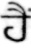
ਹੈਂ
